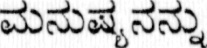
ಮನುಷ್ಯನನ್ನು
